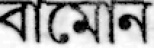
বামোন
